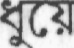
ধুয়ে
